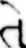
તે
